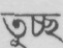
তুচ্ছ
